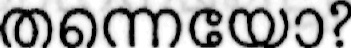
തന്നെയോ?
